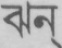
ঝন্
